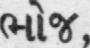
ભોજ,
